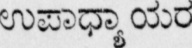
ಉಪಾಧ್ಯಾಯರ
